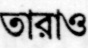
তারাও
